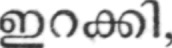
ഇറക്കി,
